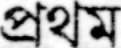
প্রথম
